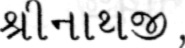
શ્રીનાથજી,
